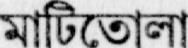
মাটিতোলা
